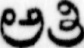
ಅತಿ
